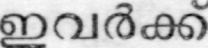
ഇവര്‍ക്ക്
